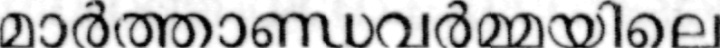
മാര്‍ത്താണ്ഡവര്‍മ്മയിലെ
